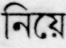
নিয়ে
